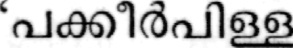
'പക്കീര്‍പിള്ള
